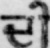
ਦੀ
